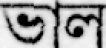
ভাল
